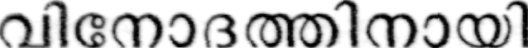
വിനോദത്തിനായി
